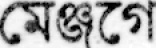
মেঞ্জগে
